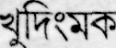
খুদিংমক
